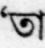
‘তা
